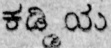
ಕಡ್ಡಿಯ
